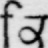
ਕਿ
